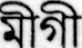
মীগী
